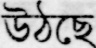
উঠছে
